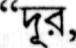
"দূর,
